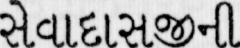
સેવાદાસજીની
